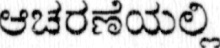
ಆಚರಣೆಯಲ್ಲಿ
